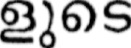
ളുടെ
